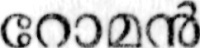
റോമന്‍
